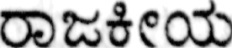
ರಾಜಕೀಯ
